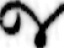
જ
